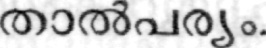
താല്‍പര്യം.
